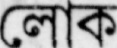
লোক
